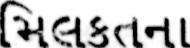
મિલકતના
